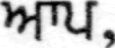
ਆਪ,
